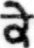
ਕੇ
